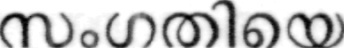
സംഗതിയെ
